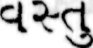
વસ્તુ
